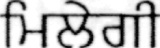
ਮਿਲੇਗੀ
